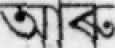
আৰু
